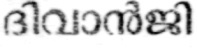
ദിവാന്‍ജി
